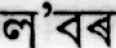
ল'বৰ
